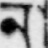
না
